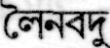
লৈনবদু
